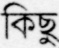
কিছু
